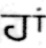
ਹਾਂ
